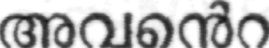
അവന്റെ
